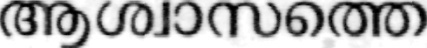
ആശ്വാസത്തെ
